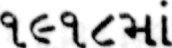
૧૯૧૮માં
